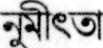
নুমীৎতা
